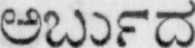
ಅರ್ಬುದ
